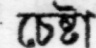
চেষ্টা
